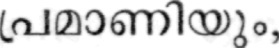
പ്രമാണിയും,
